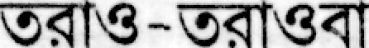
তরাও-তরাওবা
